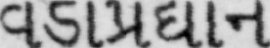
વડાપ્રધાન
